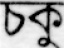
চকু
